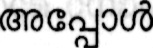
അപ്പോള്‍
